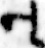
ન
